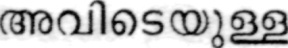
അവിടെയുള്ള
